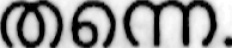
തന്നെ.
